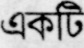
একটি
